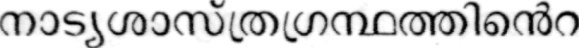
നാട്യശാസ്ത്രഗ്രന്ഥത്തിന്റെ
